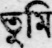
তুমি
